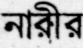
নারীর
